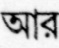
আর
